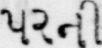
પરની
